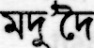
মদু’দৈ
